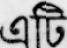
এটি
